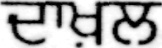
ਦਾਖ਼ਲ
